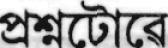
প্রশ্নটোৱে
